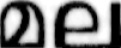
മല
